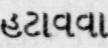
હટાવવા
